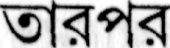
তারপর
